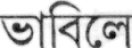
ভাবিলে
